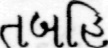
તબહિ
